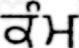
ਕੰਮ
